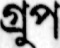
গ্রুপ
